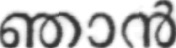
ഞാന്‍
